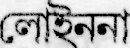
লোইননা
